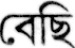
বেছি
